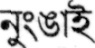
নুংঙাই
